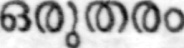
ഒരുതരം
